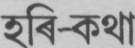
হৰি-কথা
